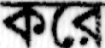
করে
